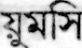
য়ুমসি
